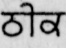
ਠੀਕ
